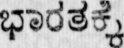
ಭಾರತಕ್ಕೆ
